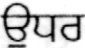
ਉਧਰ
